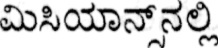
ಮಿಸಿಯಾನ್ಸ್ ನಲ್ಲಿ
